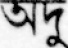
অদু
